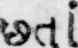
છતાં
